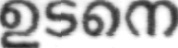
ഉടനെ
